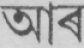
আৰ
